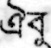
ঐবু
